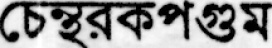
চেন্থরকপগুম
